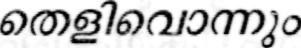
തെളിവൊന്നും
